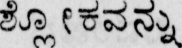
ಶ್ಲೋಕವನ್ನು
